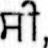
ਸੀ,
